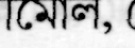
বীমোল,
